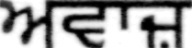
ਅਵਾਜ਼
